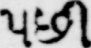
પછી
